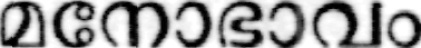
മനോഭാവം
